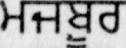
ਮਜਬੂਰ
